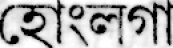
হোংলগা
